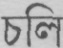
চলি
